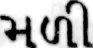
મળી
